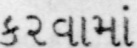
કરવામાં
